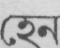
হেন
